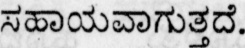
ಸಹಾಯವಾಗುತ್ತದೆ.
